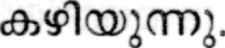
കഴിയുന്നു.
